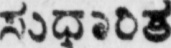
ಸುಧಾರಿತ
